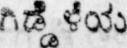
ಗಿಡ್ಡೆಳೆಯ
